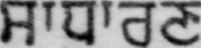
ਸਾਧਾਰਣ
